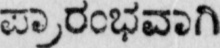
ಪ್ರಾರಂಭವಾಗಿ
